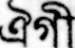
ঐগী
